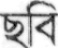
ছবি
